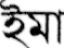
ইমা
